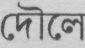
দৌলে
